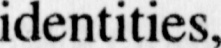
identities,
